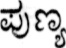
ಪುಣ್ಯ
